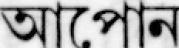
আপোন
